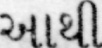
આથી
